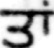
ਤਾਂ
